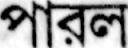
পারল
